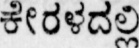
ಕೇರಳದಲ್ಲಿ
